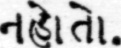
નહોતો.
